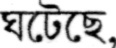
ঘটেছে,
